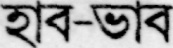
হাব-ভাব
